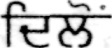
ਦਿਲੋਂ
